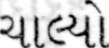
ચાલ્યો
